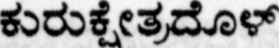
ಕುರುಕ್ಷೇತ್ರದೊಳ್
